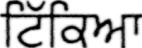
ਟਿੱਕਿਆ
